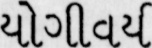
યોગીવર્ય
